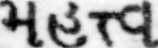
મહત્વ
